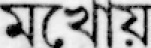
মখোয়
